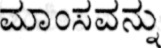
ಮಾಂಸವನ್ನು
